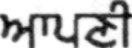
ਆਪਣੀ
